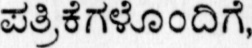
ಪತ್ರಿಕೆಗಳೊಂದಿಗೆ,
